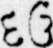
દઉં
